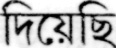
দিয়েছি
